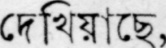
দেখিয়াছে,
